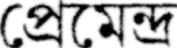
প্রেমেন্দ্র
